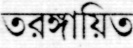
তরঙ্গায়িত
